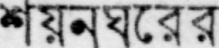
শয়নঘরের
